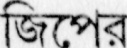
জিপের
